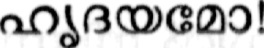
ഹൃദയമോ!
